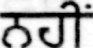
ਨਹੀਂ
